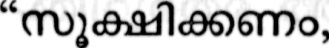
“സൂക്ഷിക്കണം,
